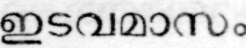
ഇടവമാസം
